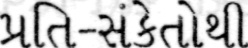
પ્રતિ-સંકેતોથી
